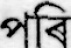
পৰি
